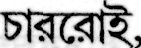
চাররোই,
